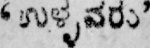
‘ಉಳ್ಳವರು’
